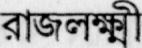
রাজলক্ষ্মী
